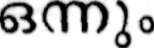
ഒന്നും
